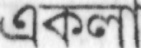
একলা
